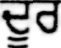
ਦੂਰ
